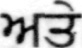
ਅਤੇ
